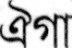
ঐগা
